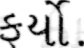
ફર્યો.
